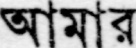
আমার
